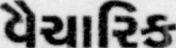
વૈચારિક
